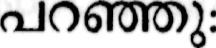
പറഞ്ഞു:
